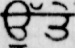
ਉੱਤੇ
